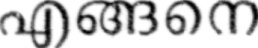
എങ്ങനെ
